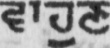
ਵਾਹੁਣ
